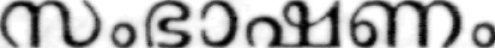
സംഭാഷണം
